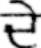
ਦੇ
